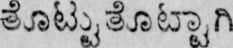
ತೊಟ್ಟುತೊಟ್ಟಾಗಿ
